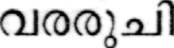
വരരുചി
